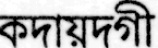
কদায়দগী
